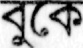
বুকে
